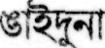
ঙাইদুনা
